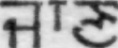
ਜਾਣ
